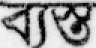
ব্যস্ত
